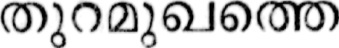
തുറമുഖത്തെ
